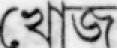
খোজ
